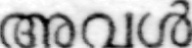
അവള്‍
